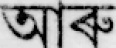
আৰু
